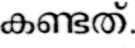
കണ്ടത്.
